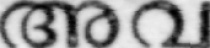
അവ
